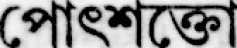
পোৎশক্তো
